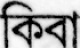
কিবা
